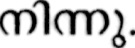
നിന്നു.
